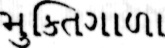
મુક્તિગાળા
